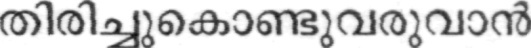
തിരിച്ചുകൊണ്ടുവരുവാന്‍
